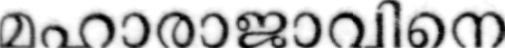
മഹാരാജാവിനെ
